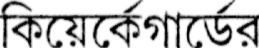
কিয়ের্কেগার্ডের
